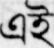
এই
